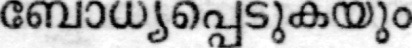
ബോധ്യപ്പെടുകയും
